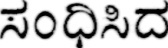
ಸಂಧಿಸಿದ
